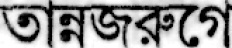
তান্নজরুগে
